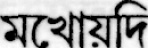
মখোয়দি
